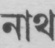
নাথ
